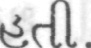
હતી.
